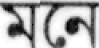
মনে
